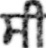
ਸੀ
